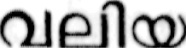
വലിയ
